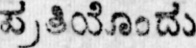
ಪ್ರತಿಯೊಂದು
